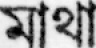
মাথা
